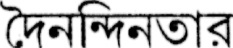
দৈনন্দিনতার
